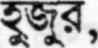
হুজুর,
